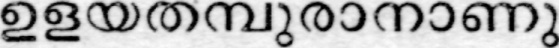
ഉളയതമ്പുരാനാണു
